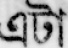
এটা
